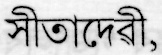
সীতাদেৱী,
